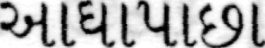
આઘાપાછા
